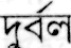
দুর্বল
